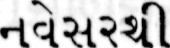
નવેસરથી
